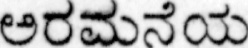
ಅರಮನೆಯ
